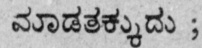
ಮಾಡತಕ್ಕುದು:
